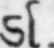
ર્ડા.
